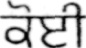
ਕੋਈ
